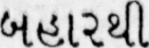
બહારથી
